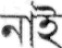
নাই
